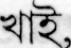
খাই,
